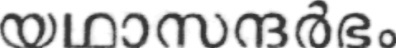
യഥാസന്ദര്‍ഭം
